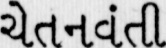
ચેતનવંતી
